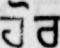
ਹੋਰ
